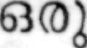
ഒരു
